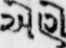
એણે
